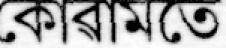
কোৱামতে
